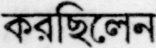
করছিলেন
